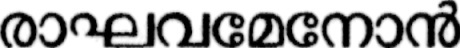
രാഘവമേനോന്‍
